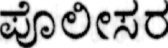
ಪೊಲೀಸರ
